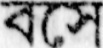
বসে
